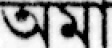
অমা
